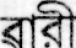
ৱারী
